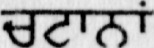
ਚਟਾਨਾਂ
